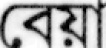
বেয়া
